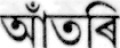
আঁতৰি
